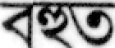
বহুত
